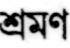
শ্রমণ
